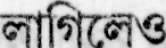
লাগিলেও
